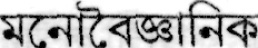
মনোবৈজ্ঞানিক
